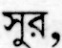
সুর,
